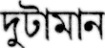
দুটামান
